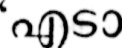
‘എടാ
